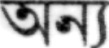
অন্য
